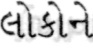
લોકોને
